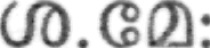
ശ.മേ:
